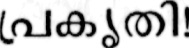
പ്രകൃതി!
